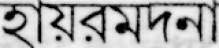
হায়রমদনা
